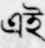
এই
